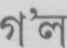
গ'ল
